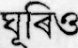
ঘূৰিও
